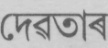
দেৱতাৰ
